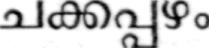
ചക്കപ്പഴം
